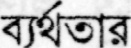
ব্যর্থতার
